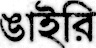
ঙাইরি
